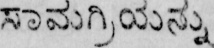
ಸಾಮಗ್ರಿಯನ್ನು
